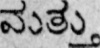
ಮತ್ತು
